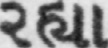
રહ્યા
